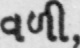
વળી,
